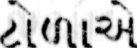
ટોળાએ
